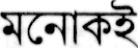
মনোকই
